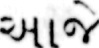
આજે
